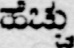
ಹೆಚ್ಚು
